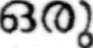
ഒരു
